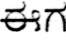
ಈಗ
